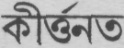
কীৰ্ত্তনত
